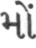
મોં
